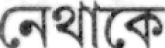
নেথাকে
